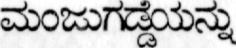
ಮಂಜುಗಡ್ಡೆಯನ್ನು
